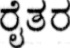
ರೈತರ
